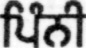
ਪਿੰਨੀ
